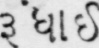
રૂંધાઈ
